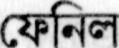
ফেনিল
